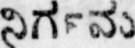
ನಿರ್ಗಮ
